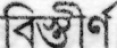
বিস্তীৰ্ণ
